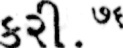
કરી.૭૬
